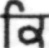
ਕਿ
